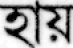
হায়
